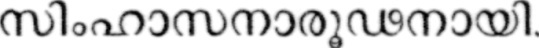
സിംഹാസനാരൂഢനായി.
